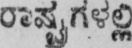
ರಾಷ್ಟ್ರಗಳಲ್ಲಿ
